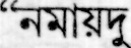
“নমায়দু
